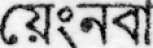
য়েংনবা
